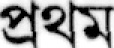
প্রথম
